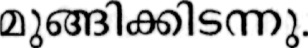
മുങ്ങിക്കിടന്നു.
